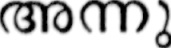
അന്നു
